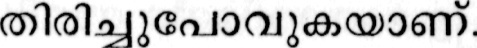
തിരിച്ചുപോവുകയാണ്.
